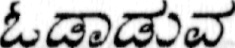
ಓಡಾಡುವ
